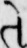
તે
